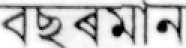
বছৰমান
